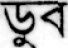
ডুব
